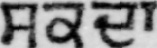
ਸਕਦਾ
